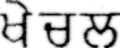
ਖੇਚਲ
